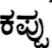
ಕಪ್ಪು
